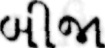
બીજા
